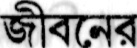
জীবনের
